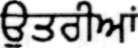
ਉਤਰੀਆਂ
